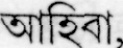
আহিবা,
